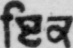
ਇਕ
